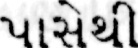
પાસેથી
